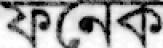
ফনেক
